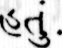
હતું.
